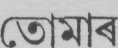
তোমাৰ
